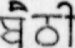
ਬੈਠੀ
